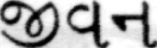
જીવન
